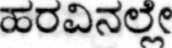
ಹರವಿನಲ್ಲೇ
